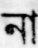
না
